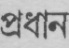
প্রধান
